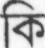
কি
